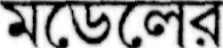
মডেলের
